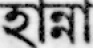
হান্না
